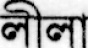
লীলা
